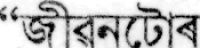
"জীৱনটোৰ
